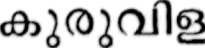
കുരുവിള
